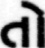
તો
